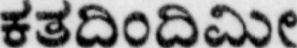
ಕತದಿಂದಿಮೀ
